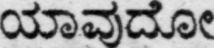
ಯಾವುದೋ
